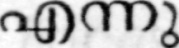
എന്നു
